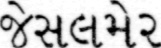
જેસલમેર
